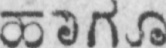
ಹಾಗೂ
